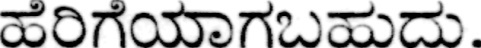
ಹೆರಿಗೆಯಾಗಬಹುದು.
